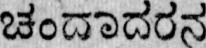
ಚಂದಾದರನ
